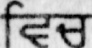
ਵਿਚ
